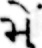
મેં
